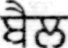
ਬੈਲ
